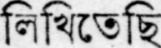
লিখিতেছি
